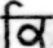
ਕਿ
